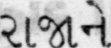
રાજાને
